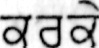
ਕਰਕੇ
